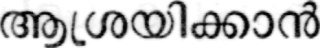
ആശ്രയിക്കാന്‍
